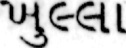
ખુલ્લા
